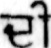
ਦੀ
